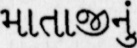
માતાજીનું
